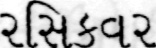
રસિકવર
